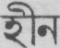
হীন
